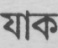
যাক
